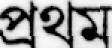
প্রথম
